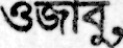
ওজাবু,
